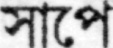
সাপে
